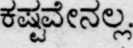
ಕಷ್ಟವೇನಲ್ಲ.
